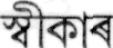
স্বীকাৰ
